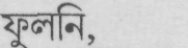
ফুলনি,
